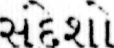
સંદેશો
